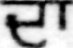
ਦਾ
